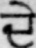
ਦੇ
